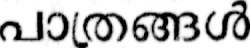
പാത്രങ്ങള്‍
